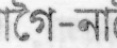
গৈ না
